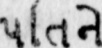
પતિને
